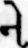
ને
